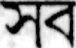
সব
